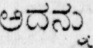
ಅದನ್ನು
